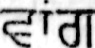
ਵਾਂਗ
